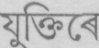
যুক্তিৰে
